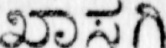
ಖಾಸಗಿ
